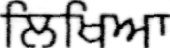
ਲਿਖਿਆ
